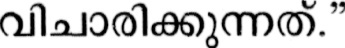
വിചാരിക്കുന്നത്."
